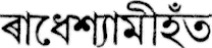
ৰাধেশ্যামীহঁত
